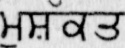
ਮੁਸ਼ੱਕਤ
